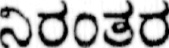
ನಿರಂತರ
